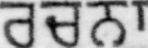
ਰਚਨਾ
